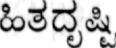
ಹಿತದೃಷ್ಟಿ
